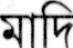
মাদি
